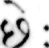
છેઃ
